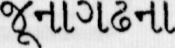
જૂનાગઢના
